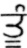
ਤੂੰ
